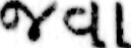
જવા
